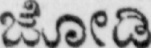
ಜೋಡಿ
